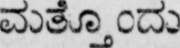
ಮತ್ತೊಂದು
